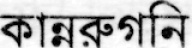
কান্নরুগনি
